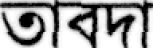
তাবদা
